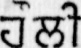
ਹੌਲੀ
